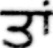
ਤਾਂ
